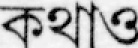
কথাও
